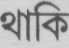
থাকি
